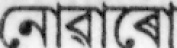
নোৱাৰো
